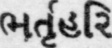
ભર્તૃહરિ
